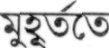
মুহূর্ততে
